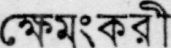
ক্ষেমংকরী
